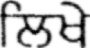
ਲਿਖੇ
